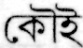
কৌই
